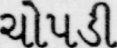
ચોપડી
